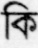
কি
